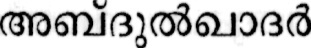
അബ്ദുല്‍ഖാദര്‍
